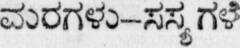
ಮರಗಳು-ಸಸ್ಯಗಳೆ
